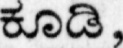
ಕೂಡಿ,
